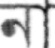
না
